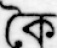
কৈ
